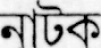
নাটক
